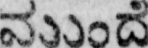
ಮುಂದೆ
